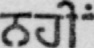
ਨਹੀਂ
